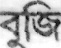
বুজি
